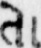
તો
